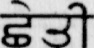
ਛੇਤੀ
